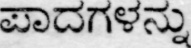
ಪಾದಗಳನ್ನು
